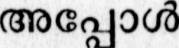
അപ്പോള്‍
